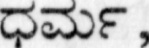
ಧರ್ಮ,
